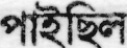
পাইছিল
